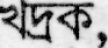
খদ্রক,
